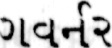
ગવર્નર
